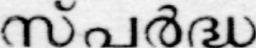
സ്പര്‍ദ്ധ
